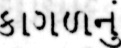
કાગળનું
